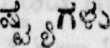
ಷ್ಟ್ಯಗಳು
